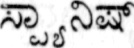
ಸ್ಪ್ಯಾನಿಷ್
